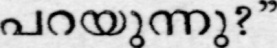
പറയുന്നു?"
